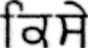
ਕਿਸੇ
